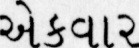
એકવાર
